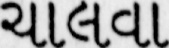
ચાલવા
